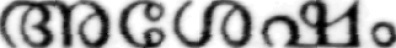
അശേഷം
